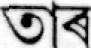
তাৰ
